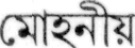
মোহনীয়
